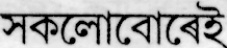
সকলোবোৰেই
